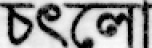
চৎলো
